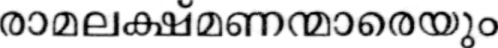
രാമലക്ഷ്മണന്മാരെയും
